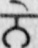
ਨੇ
